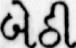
બેઠી
